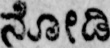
ನೋಡಿ
